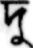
দু
